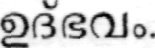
ഉദ്ഭവം.
